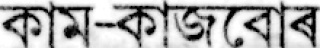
কাম-কাজবোৰ
